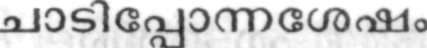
ചാടിപ്പോന്നശേഷം
